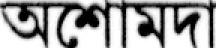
অশোমদা
